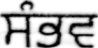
ਸੰਭਵ
